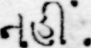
નહીં.
